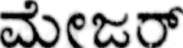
ಮೇಜರ್
